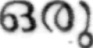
ഒരു
